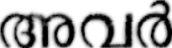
അവര്‍
